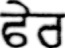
ਫੇਰ
